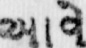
આવે
